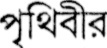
পৃথিবীর
